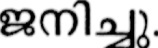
ജനിച്ചു.
